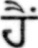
ਹੈਂ
